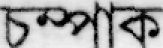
চম্পাক
